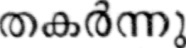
തകര്‍ന്നു
